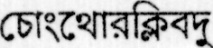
চোংথোরক্লিবদু
